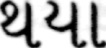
થયા
